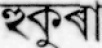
হুকুৰা
